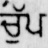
ਚੁੱਪ
